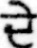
ਦੇ
